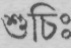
শুচিঃ
